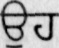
ਉਹ
